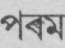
পৰম
